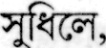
সুধিলে,
